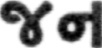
જન
